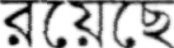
রয়েছে
